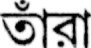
তাঁরা
